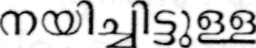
നയിച്ചിട്ടുള്ള
